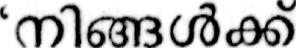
‘നിങ്ങള്‍ക്ക്
